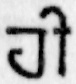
ਹੀ
